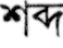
শব্দ
